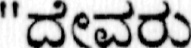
“ದೇವರು
